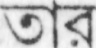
তার
